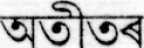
অতীতৰ
